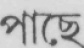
পাছে
